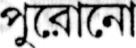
পুরোনো
